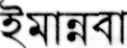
ইমান্নবা
